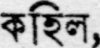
কহিল,
